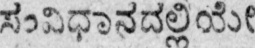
ಸಂವಿಧಾನದಲ್ಲಿಯೇ
